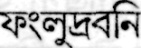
ফংলুদ্রবনি
